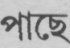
পাছে
